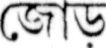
জোড়
